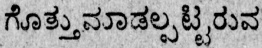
ಗೊತ್ತುಮಾಡಲ್ಪಟ್ಟಿರುವ
